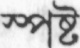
স্পষ্ট
